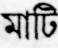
মাটি
